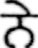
ਨੇ
